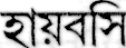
হায়বসি
